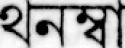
থনম্বা
